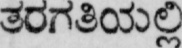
ತರಗತಿಯಲ್ಲಿ
